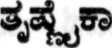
ತೃಷ್ಣೈಕಾ
